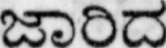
ಜಾರಿದ
